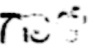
ಗಾಳಿ
